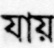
যায়
